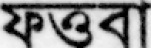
ফত্তবা
